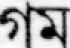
গম
